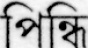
পিন্ধি
